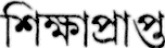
শিক্ষাপ্রাপ্ত
